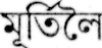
মূৰ্তিলৈ
